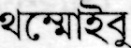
থম্মোইবু
